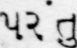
પરંતુ
